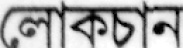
লোকচান
